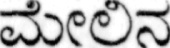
ಮೇಲಿನ
